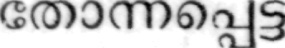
തോന്നപ്പെട്ട
